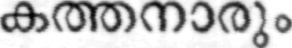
കത്തനാരും
